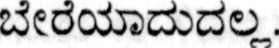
ಬೇರೆಯಾದುದಲ್ಲ.
